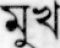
মুখ
